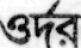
ওর্দর
